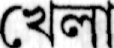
খেলা
